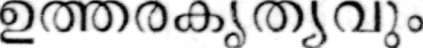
ഉത്തരകൃത്യവും
